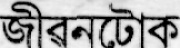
জীৱনটোক
